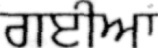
ਗਈਆਂ
